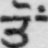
ਤੋਂ
